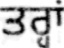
ਤਰ੍ਹਾਂ
